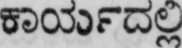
ಕಾರ್ಯದಲ್ಲಿ
